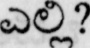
ಎಲ್ಲಿ?
